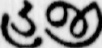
હજી
